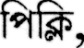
পিক্লি,
